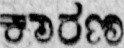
ಕಾರಣ
